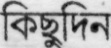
কিছুদিন
